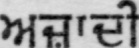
ਅਜ਼ਾਦੀ
